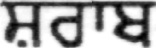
ਸ਼ਰਾਬ
